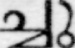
ച്ചു
